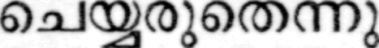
ചെയ്യരുതെന്നു
